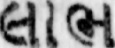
લાભ
